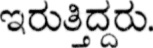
ಇರುತ್ತಿದ್ದರು.
